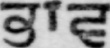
ਭਾਵ
